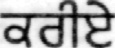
ਕਰੀਏ
